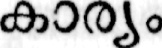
കാര്യം
